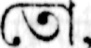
তো,
